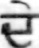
ਦੇ
